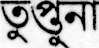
তুপ্তুনা
